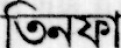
তিনফা
